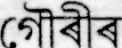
গৌৰীৰ
